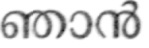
ഞാന്‍
